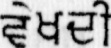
ਵੇਖਦੀ
